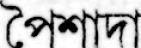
পৈশাদা
